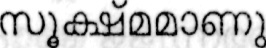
സൂക്ഷ്മമാണു
